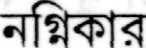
নগ্নিকার
